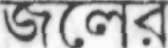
জলের
